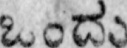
ಒಂದು
